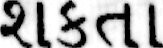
શકતા
